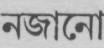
নজানো
